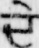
ਦੇ
